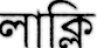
লাক্লি
